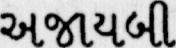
અજાયબી
